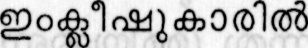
ഇംക്ലീഷുകാരില്‍
